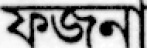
ফজনা
